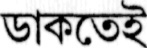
ডাকতেই
